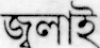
জ্বলাই
